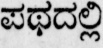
ಪಥದಲ್ಲಿ
